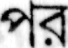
পর
